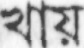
খায়
